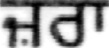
ਜ਼ਰਾ
